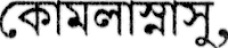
কোমলাস্নাসু,
